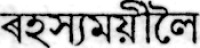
ৰহস্যময়ীলৈ
